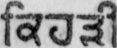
ਕਿਹੜੀ
